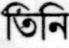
তিনি
